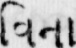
વિના
